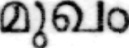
മുഖം
